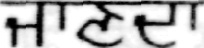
ਜਾਣਦਾ
